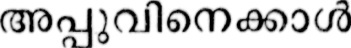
അപ്പുവിനെക്കാള്‍
